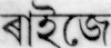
ৰাইজে
